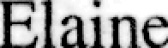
Elaine
